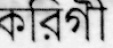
করিগী
